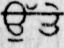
ਉੱਤੇ
